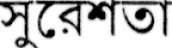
সুরেশতা
